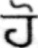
ਹੋ
